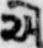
એ
